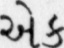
એક
